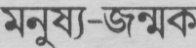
মনুষ্য-জন্মক
